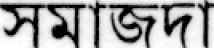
সমাজদা
